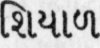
શિયાળ
